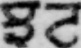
ਝਟ
